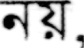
নয়,
